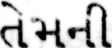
તેમની
